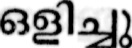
ഒളിച്ചു
